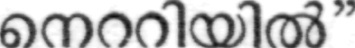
നെററിയില്‍”
